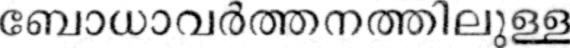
ബോധാവര്‍ത്തനത്തിലുള്ള
